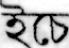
ইচে
